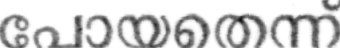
പോയതെന്ന്
